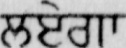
ਲਏਗਾ
